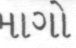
માગો
